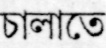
চালাতে
